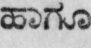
ಹಾಗೂ
